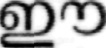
ഈ
